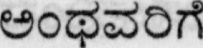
ಅಂಥವರಿಗೆ
